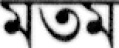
মতম
